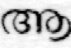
ആ
